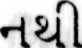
નથી
